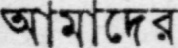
আমাদের
